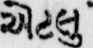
એટલું
